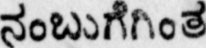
ನಂಬುಗೆಗಿಂತ
